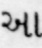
આ
